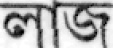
লাজ
